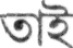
তাই
